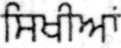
ਸਿਖੀਆਂ
